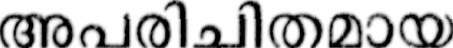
അപരിചിതമായ
